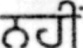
ਨਹੀਂ
